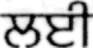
ਲਈ
